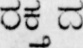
ರಕ್ತದ
